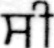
ਸੀ
